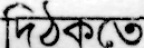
দিঠকতে
